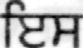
ਇਸ
